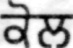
ਕੋਲ
